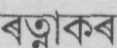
ৰত্নাকৰ
